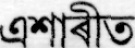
এশাৰীত
